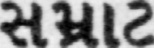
સમ્રાટ
